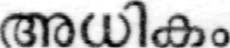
അധികം
